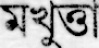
মখুত্তা
